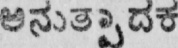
ಅನುತ್ಪಾದಕ
